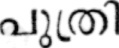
പുത്രി
